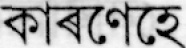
কাৰণেহে
